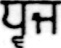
ਧ੍ਵਜ
